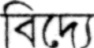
বিদ্যে
